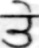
ਤੇ
